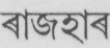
ৰাজহাৰ
